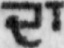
ਦਾ
